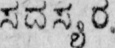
ಸದಸ್ಯರ
